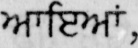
ਆਇਆਂ,
